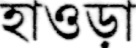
হাওড়া
